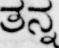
ತನ್ನ
